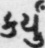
કર્યું
